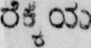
ರೆಕ್ಕೆಯ
